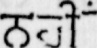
ਨਹੀਂ
